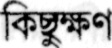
কিছুক্ষণ
